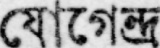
যোগেন্দ্র
